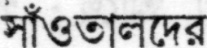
সাঁওতালদের
